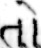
તો
